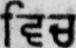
ਵਿਚ
